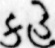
કહે
